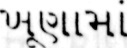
ખૂણામાં
